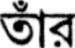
তাঁর
